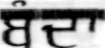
ਬੰਦਾ
